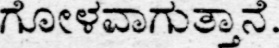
ಗೋಳವಾಗುತ್ತಾನೆ.
